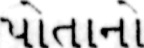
પોતાનો
